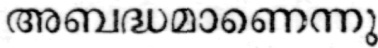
അബദ്ധമാണെന്നു
